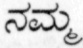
ನಮ್ಮ
